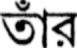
তাঁর
